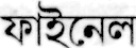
ফাইনেল
